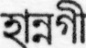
হান্নগী
